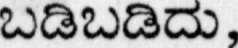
ಬಡಿಬಡಿದು,
